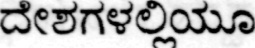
ದೇಶಗಳಲ್ಲಿಯೂ
